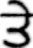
ਤੇ
